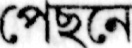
পেছনে
